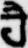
ਹੈ
